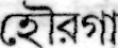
হৌরগা
